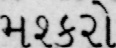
મશ્કરો
